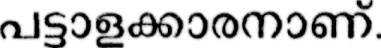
പട്ടാളക്കാരനാണ്.
